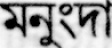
মনুংদা
